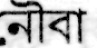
নৌবা
